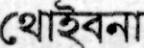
থোইবনা
